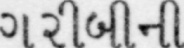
ગરીબીની
